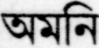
অমনি
